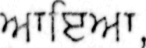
ਆਇਆ,
